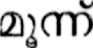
മൂന്ന്
